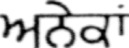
ਅਨੇਕਾਂ
